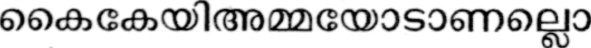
കൈകേയിഅമ്മയോടാണല്ലൊ
